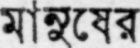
মানুষের
